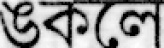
ঙকলে
